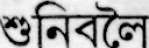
শুনিবলৈ
